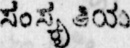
ಸಂಸ್ಕೃತಿಯ
